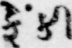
ફેંકી
